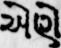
એણે
